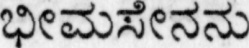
ಭೀಮಸೇನನು
